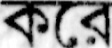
করে
